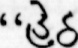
"હેઠ
